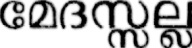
മേദസ്സല്ല
